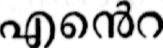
എന്റെ
